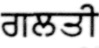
ਗਲਤੀ
